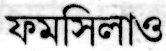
ফমসিলাও
